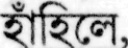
হাঁহিলে,
